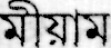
মীয়াম
